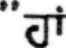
''ਹਾਂ
